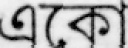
একো
